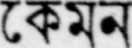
কেমন
